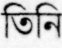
তিনি
